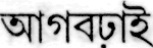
আগবঢ়াই
